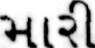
મારી
